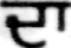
ਦਾ
